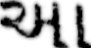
આ
